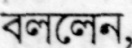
বললেন,
